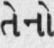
તેનો
